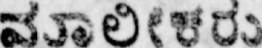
ಮಾಲೀಕರು
